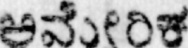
ಅಮೇರಿಕ
